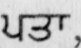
ਪਤਾ,
